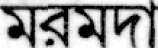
মরমদা
